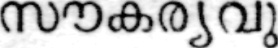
സൌകര്യവു
